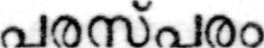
പരസ്പരം
